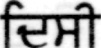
ਦਿਸੀ
